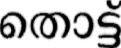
തൊട്ട്
